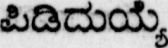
ಪಿಡಿದುಯ್ಯೆ
